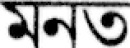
মনত
